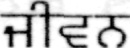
ਜੀਵਨ
